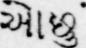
ઓછું
